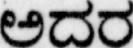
ಅದರ
